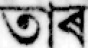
তাৰ
